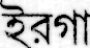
ইরগা
